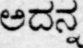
ಅದನ್ನ
